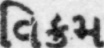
વિક્રમ
